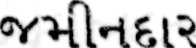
જમીનદાર
